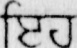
ਇਹ
